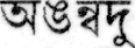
অঙম্বদু
